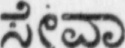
ಸೇವಾ
